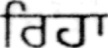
ਰਿਹਾ
